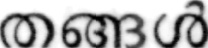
തങ്ങള്‍
